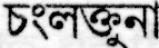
চংলক্তুনা
